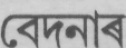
বেদনাৰ
